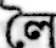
লৈ
